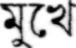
মুখে
